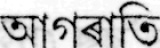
আগৰাতি
